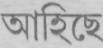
আহিছে
